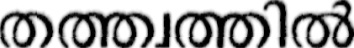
തത്ത്വത്തില്‍
